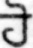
ਹੋ
